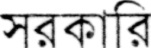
সরকারি
